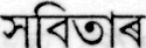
সবিতাৰ
